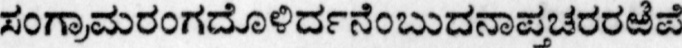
ಸಂಗ್ರಾಮರಂಗದೊಳಿರ್ದನೆಂಬುದನಾಪ್ತಚರರಱಪೆ
